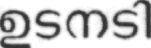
ഉടനടി
